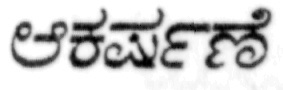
ಆಕರ್ಷಣೆ
